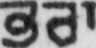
ਭਰਾ
